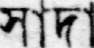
সাদা
